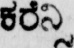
ಕರೆನ್ಸಿ
